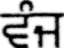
ਵੰਜ
